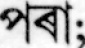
পৰা;
